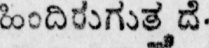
ಹಿಂದಿರುಗುತ್ತದೆ.
